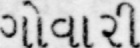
ગોવારી
